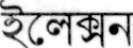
ইলেক্সন
